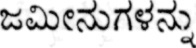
ಜಮೀನುಗಳನ್ನು
